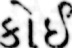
કોઈ
